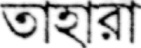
তাহারা
